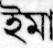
ইমা
